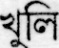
খুলি
